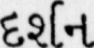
દર્શન
